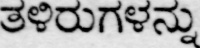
ತಳಿರುಗಳನ್ನು
